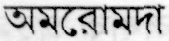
অমরোমদা
